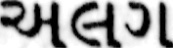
અલગ
